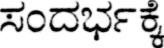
ಸಂದರ್ಭಕ್ಕೆ
